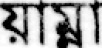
য়াম্না
